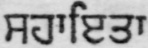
ਸਹਾਇਤਾ
